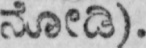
ನೋಡಿ).
